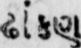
ઢાંકણ
